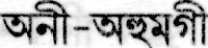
অনী-অহুমগী
